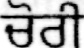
ਚੋਰੀ
